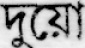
দুয়ো
